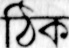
ঠিক
